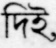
দিই,
